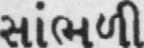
સાંભળી
